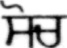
ਸੋਚ
